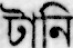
টানি
